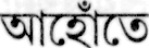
আহোঁতে
